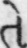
તે
